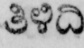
ತಿಳಿದಿ
